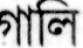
গালি
